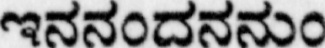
ಇನನಂದನನುಂ
